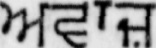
ਅਵਾਜ਼
